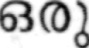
ഒരു
